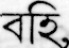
বহি,
